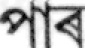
পাৰ
